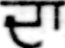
ਦਾ
